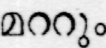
മററും
